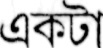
একটা
